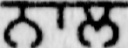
ਨਾਲ
